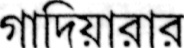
গাদিয়ারার
